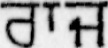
ਰਾਜ
